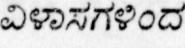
ವಿಳಾಸಗಳಿಂದ
